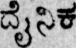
ದೈನಿಕ
